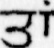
ਤਾਂ
